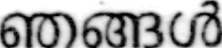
ഞങ്ങള്‍
